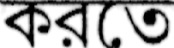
করতে
